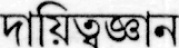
দায়িত্বজ্ঞান
